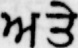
ਅਤੇ
